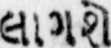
લાગશે
